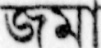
জমা
